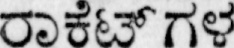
ರಾಕೆಟ್‌ಗಳ
